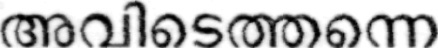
അവിടെത്തന്നെ
